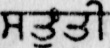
ਸਤੁਤੀ
